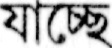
যাচ্ছে
